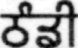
ਠੰਡੀ
